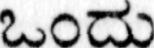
ಒಂದು
